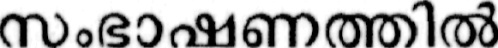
സംഭാഷണത്തില്‍
